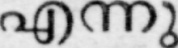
എന്നു
